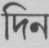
দিন
